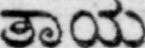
ತಾಯ
